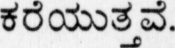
ಕರೆಯುತ್ತವೆ.
